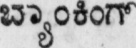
ಬ್ಯಾಂಕಿಂಗ್
